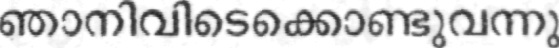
ഞാനിവിടെക്കൊണ്ടുവന്നു
